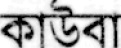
কাউবা
